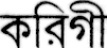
করিগী
